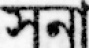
সনা
